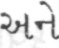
અને
